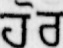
ਹੋਰ
